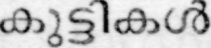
കുട്ടികള്‍
